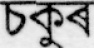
চকুৰ
